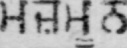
ਮਜ਼ਮੂਨ
